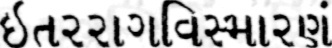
ઈતરરાગવિસ્મારણં
